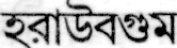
হরাউবগুম
